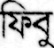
ফিবু
